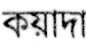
কয়াদা
